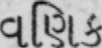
વણિક
